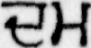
ਦਮ
